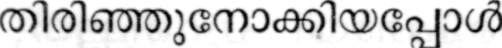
തിരിഞ്ഞുനോക്കിയപ്പോള്‍
